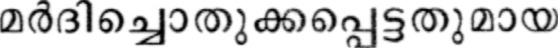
മര്‍ദിച്ചൊതുക്കപ്പെട്ടതുമായ
